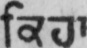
ਕਿਹਾ
